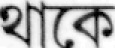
থাকে
